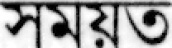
সময়ত
